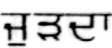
ਜੁੜਦਾ
